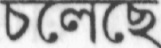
চলেছে
